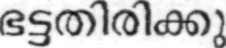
ഭട്ടതിരിക്കു
